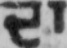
ਦਾ
